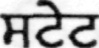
ਸਟੇਟ
